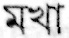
মখা
